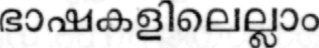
ഭാഷകളിലെല്ലാം
